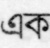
এক
